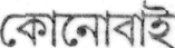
কোনোবাই
